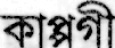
কাপ্পগী
